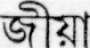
জীয়া
